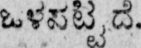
ಒಳಪಟ್ಟಿದೆ.
